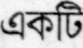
একটি
